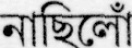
নাছিলোঁ
